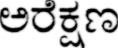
ಅರೆಕ್ಷಣ
